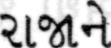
રાજાને
